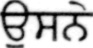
ਉਸਨੇ
